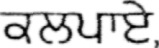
ਕਲਪਾਏ,
